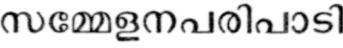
സമ്മേളനപരിപാടി
